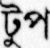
টুপ
